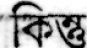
কিন্তু
